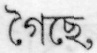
গৈছে,
